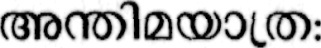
അന്തിമയാത്ര:
